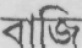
বাজি
